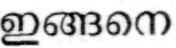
ഇങ്ങനെ
